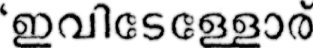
‘ഇവിടേള്ളോര്
